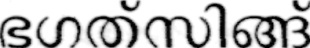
ഭഗത്സിങ്ങ്
